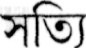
সত্যি
